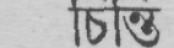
চিন্তি
